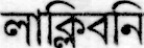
লাক্লিবনি
